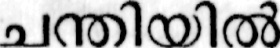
ചന്തിയില്‍
